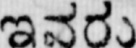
ಇವರು
